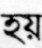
হয়
